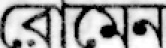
রোমেন
